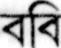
ববি
